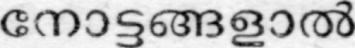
നോട്ടങ്ങളാല്‍
